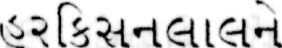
હરકિસનલાલને
